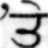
'ਤੇ
